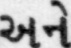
અને
